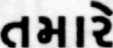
તમારે
